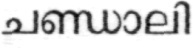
ചണ്ഡാലി
